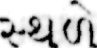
સ્થળે
